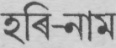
হৰি-নাম
